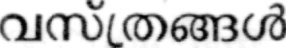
വസ്ത്രങ്ങള്‍
